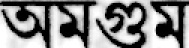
অমগুম
